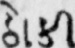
ઠોકી
